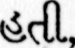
હતી,
